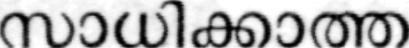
സാധിക്കാത്ത
